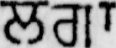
ਲਗਾ
